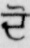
ਦੋ
